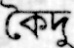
কৈদু
